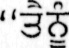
''ਤੈਨੂੰ
